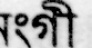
নংগী
